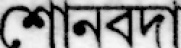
শোনবদা
